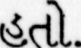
હતો.
